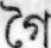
গৈ
